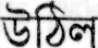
উঠিল
